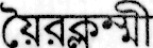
য়ৈরক্লম্মী
